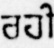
ਰਹੀ
